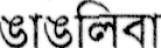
ঙাঙলিবা
